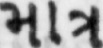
માત્ર
